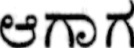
ಆಗಾಗ
